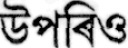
উপৰিও
